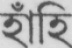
হাঁহি
